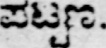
ಪಟ್ಟಣ.
